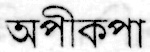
অপীকপা
